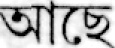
আছে
